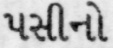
પસીનો
